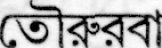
তৌরুরবা
